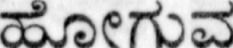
ಹೋಗುವ
